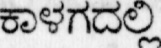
ಕಾಳಗದಲ್ಲಿ
